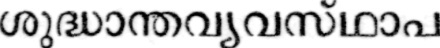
ശുദ്ധാന്തവ്യവസ്ഥാപ
